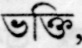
ভক্তি,
